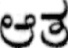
ಆತ
